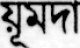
য়ূমদা
